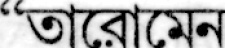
“তারোমেন
